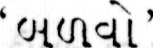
'બળવો'
